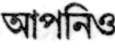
আপনিও
